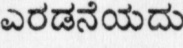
ಎರಡನೆಯದು
